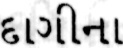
દાગીના
